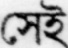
সেই
